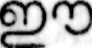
ഈ
